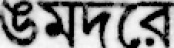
ঙমদরে
